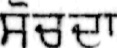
ਸੋਚਦਾ
